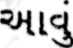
આવું
